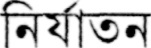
নির্যাতন
